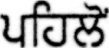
ਪਹਿਲੋਂ
